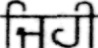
ਜਿਹੀ
